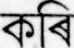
কৰি
